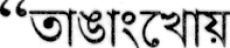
“তাঙাংখোয়
